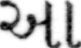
આ
